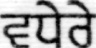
ਵਧੇਰੇ
